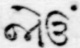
જોઉં
